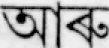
আৰু
